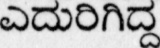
ಎದುರಿಗಿದ್ದ
